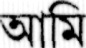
আমি
